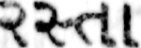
રસ્તા
